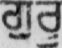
ਗੁਰੂ
